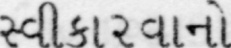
સ્વીકારવાનો
